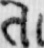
તો
